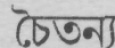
চৈতন্য
